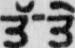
ਤੱਤੇ
